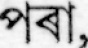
পৰা,
